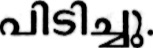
പിടിച്ചു.
